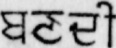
ਬਣਦੀ
